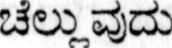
ಚೆಲ್ಲುವುದು
